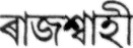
ৰাজশ্বাহী
